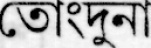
তোংদুনা
